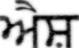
ਐਸ਼
